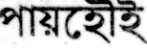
পায়হৌই
